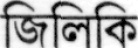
জিলিকি
